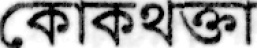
কোকথক্তা
